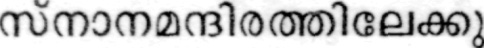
സ്നാനമന്ദിരത്തിലേക്കു
